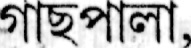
গাছপালা,
